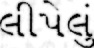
લીપેલું
